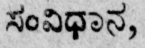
ಸಂವಿಧಾನ,
